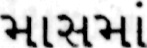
માસમાં
